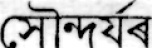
সৌন্দর্যৰ
